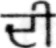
ਦੀ
